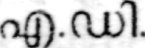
എ.ഡി.
